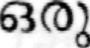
ഒരു
